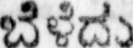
ಬೆಳೆದು
